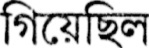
গিয়েছিল
